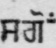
ਸਗੋਂ
